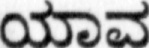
ಯಾವ
